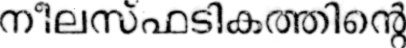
നീലസ്ഫടികത്തിന്റെ
